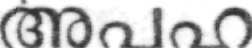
അപഹ
